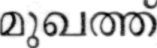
മുഖത്ത്
